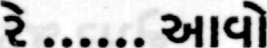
રે......આવો
